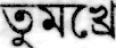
তুমখ্রে
